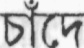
চাঁদে
